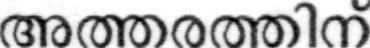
അത്തരത്തിന്
